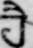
ਹੈ
